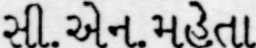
સી.એન.મહેતા
